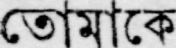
তোমাকে
